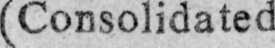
(Consolidated
